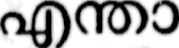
എന്താ
